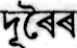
দূৰৈৰ
